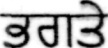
ਭਗਤੇ
